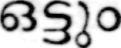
ഒട്ടും
